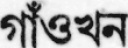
গাঁওখন
